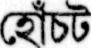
হোঁচট
